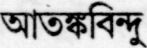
আতঙ্কবিন্দু
